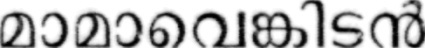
മാമാവെങ്കിടന്‍
